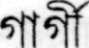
গার্গী
